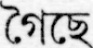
গৈছে
